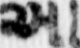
આ
